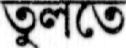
তুলতে
